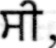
ਸੀ,
